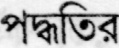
পদ্ধতির
